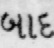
બાદ
